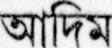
আদিম
